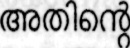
അതിന്റെ
